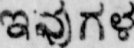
ಇವುಗಳ
